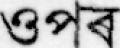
ওপৰ
